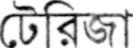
টেরিজা
